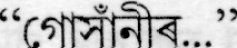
"গোসাঁনীৰ..."
